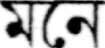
মনে
